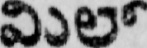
ಮಿಲ್
